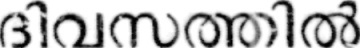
ദിവസത്തില്‍
